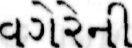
વગેરેની
